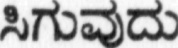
ಸಿಗುವುದು
